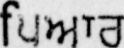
ਪਿਆਰ
